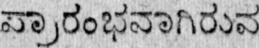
ಪ್ರಾರಂಭವಾಗಿರುವ
